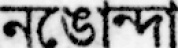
নঙোন্দা
